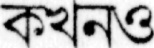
কখনও
